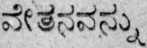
ವೇತನವನ್ನು
